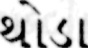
થોડા
